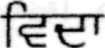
ਵਿਦਾ
